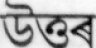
উত্তৰ
